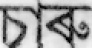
চাৰু
